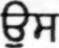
ਉਸ
